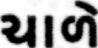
ચાળે
